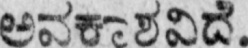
ಅವಕಾಶವಿದೆ.
